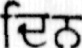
ਦਿਨ
